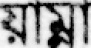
য়াম্না
